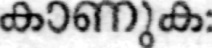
കാണുക:
